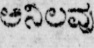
ಅನಿಲವು
